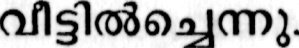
വീട്ടില്‍ച്ചെന്നു.
